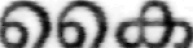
കൈ
